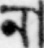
না
